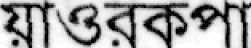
য়াওরকপা
